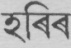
হৰিৰ
